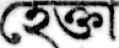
হেক্তা
